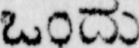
ಒಂದು
